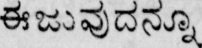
ಈಜುವುದನ್ನೂ
